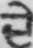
ਦੇ
